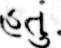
હતું.
